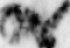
જ
